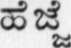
ಹೆಜ್ಜೆ
